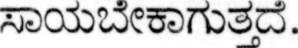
ಸಾಯಬೇಕಾಗುತ್ತದೆ.
